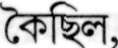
কৈছিল,
